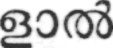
ളാല്‍
